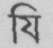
যি
